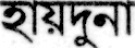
হায়দুনা
